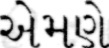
એમણે
